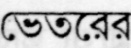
ভেতরের
